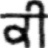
ਕੀ
